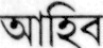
আহিব
